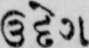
ઉદેગ
